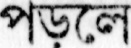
পড়লে
